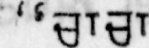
''ਚਾਚਾ
